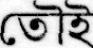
তৌই
